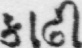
કાઢી
